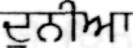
ਦੁਨੀਆ
